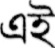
এই
